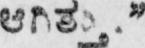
ಆಗಿತ್ತು.”
